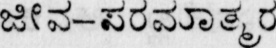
ಜೀವ-ಪರಮಾತ್ಮರ
